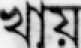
খায়
